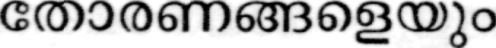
തോരണങ്ങളെയും
